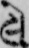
લે
